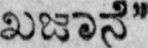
ಖಜಾನೆ”
